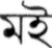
মই
